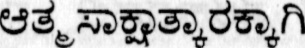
ಆತ್ಮಸಾಕ್ಷಾತ್ಕಾರಕ್ಕಾಗಿ
